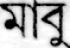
মাবু
